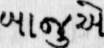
બાજુએ
